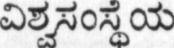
ವಿಶ್ವಸಂಸ್ಥೆಯ
